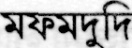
মফমদুদি
